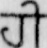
ਹੀ
